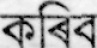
কৰিব
